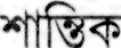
শান্তিক
